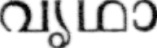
വൃഥാ
